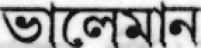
ভালেমান
